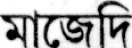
মাজেদি
